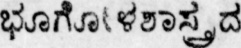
ಭೂಗೋಳಶಾಸ್ತ್ರದ
